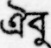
ঐবু
